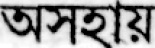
অসহায়
